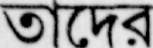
তাদের
